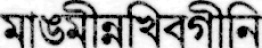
মাঙমীন্নখিবগীনি
